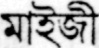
মাইজী
